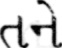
તને
